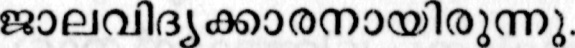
ജാലവിദ്യക്കാരനായിരുന്നു.
